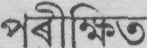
পৰীক্ষিত
